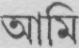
আমি
